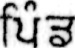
ਪਿੰਡ
